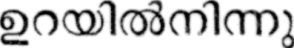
ഉറയില്‍നിന്നു
